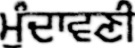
ਮੁੰਦਾਵਣੀ
